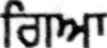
ਗਿਆ
